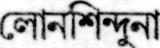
লোনশিন্দুনা
